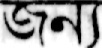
জন্য
